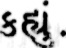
કહ્યું.
